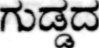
ಗುಡ್ಡದ
